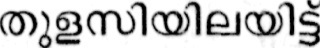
തുളസിയിലയിട്ട്
